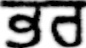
ਭਰ
